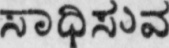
ಸಾಧಿಸುವ
